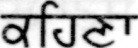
ਕਹਿਣਾ
